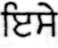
ਇਸੇ
